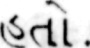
હતો.
